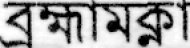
ব্রহ্মমক্না
